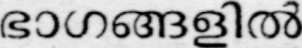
ഭാഗങ്ങളില്‍
